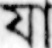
যা
